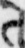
તે
